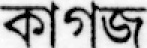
কাগজ
